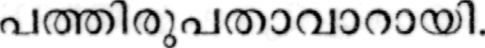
പത്തിരുപതാവാറായി.
